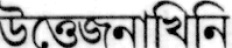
উত্তেজনাখিনি
